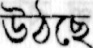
উঠছে
